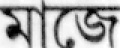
মাজে
